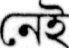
নেই
